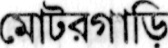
মোটরগাড়ি
